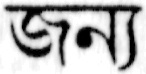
জন্য
